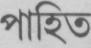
পাহিত
